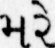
મરે
